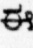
ಈ
